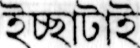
ইচ্ছাটাই
